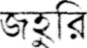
জহুরি
